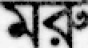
মরু
